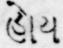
હોય
